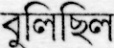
বুলিছিল
